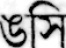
ঙসি
